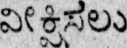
ವೀಕ್ಷಿಸಲು
